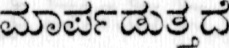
ಮಾರ್ಪಡುತ್ತದೆ
